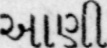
આણી
